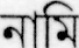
নামি
